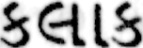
કલાક
